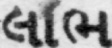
લાભ
